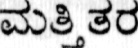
ಮತ್ತಿತರ
